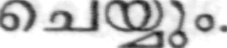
ചെയ്യും.
